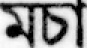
মচা
